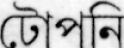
টোপনি
